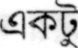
একটু
